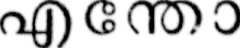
എന്തോ
